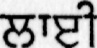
ਲਾਈ
